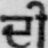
ਦੀ
